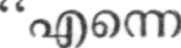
"എന്നെ
